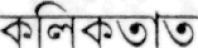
কলিকতাত
